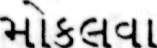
મોકલવા
